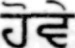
ਹੋਵੇ
